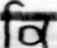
ਕਿ
